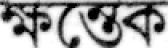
ক্ষন্তেক
